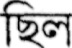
ছিল
